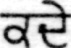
ਕਦੇ
